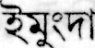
ইমুংদা
